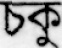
চকু
